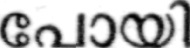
പോയി
